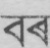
বৰ
